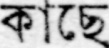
কাছে
